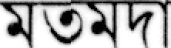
মতমদা
